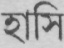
হাসি
